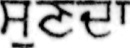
ਸੁਣਦਾ
